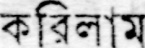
করিলাম
